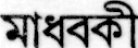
মাধবকী
